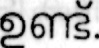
ഉണ്ട്.
